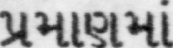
પ્રમાણમાં
